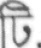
টি.
